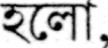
হলো,
